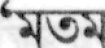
‘মতম
